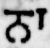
ਨਾ
